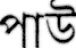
পাউ
